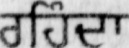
ਰਹਿੰਦਾ
